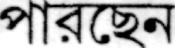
পারছেন
